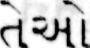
તેઓ
